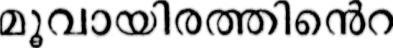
മൂവായിരത്തിന്റെ
